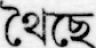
থৈছে
